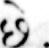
છે.
